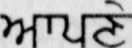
ਆਪਣੇ
